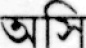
অসি
